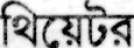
থিয়েটর
